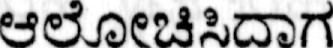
ಆಲೋಚಿಸಿದಾಗ
